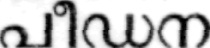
പീഡന
